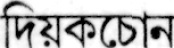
দিয়কচোন
